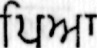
ਪਿਆ
